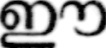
ഈ
